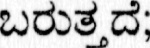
ಬರುತ್ತದೆ;
